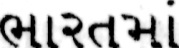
ભારતમાં
